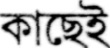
কাছেই
